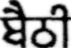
ਬੈਠੀ
